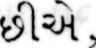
છીએ,
